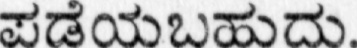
ಪಡೆಯಬಹುದು.
